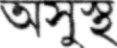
অসুস্থ
